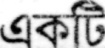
একটি
